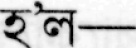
হ'ল-
